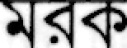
মরক
